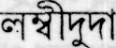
লম্বীদুদা
